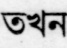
তখন
